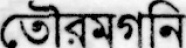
তৌরমগনি
